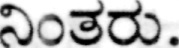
ನಿಂತರು.
